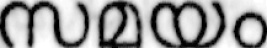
സമയം
